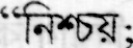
"নিশ্চয়;
